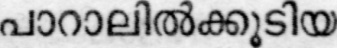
പാറാലില്‍ക്കൂടിയ
